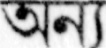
অন্য
